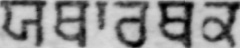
ਯਥਾਰਥਕ
